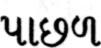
પાછળ
